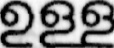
ഉള്ള
